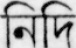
নিদি
